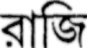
রাজি
